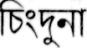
চিংদুনা
